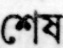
শেষ
